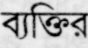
ব্যক্তির
